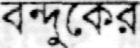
বন্দুকের
